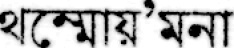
থম্মোয়’মনা
